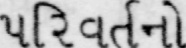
પરિવર્તનો
